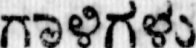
ಗಾಳಿಗಳು
